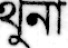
থুনা
